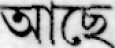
আছে
